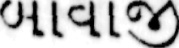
બાવાજી
